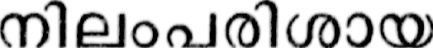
നിലംപരിശായ
